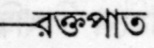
–রক্তপাত
